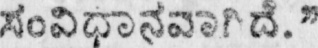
ಸ೦ವಿಧಾನವಾಗಿದೆ.”
